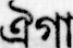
ঐগা
